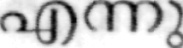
എന്നു
